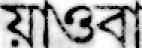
য়াওবা
